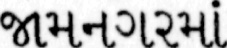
જામનગરમાં
